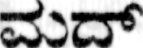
ಮದ್
